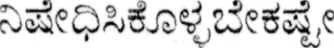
ನಿಷೇಧಿಸಿಕೊಳ್ಳಬೇಕಷ್ಟೇ
